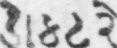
ડોકટરે
